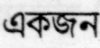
একজন
